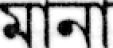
মানা
